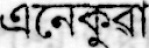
এনেকুৱা
